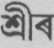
শ্ৰীৰ
